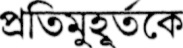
প্রতিমুহূর্তকে
